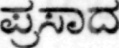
ಪ್ರಸಾದ
